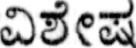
ವಿಶೇಷ
